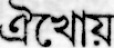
ঐখোয়
